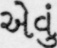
એવું
